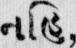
નહિ,
